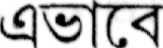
এভাবে
